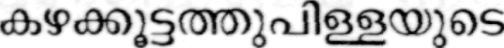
കഴക്കൂട്ടത്തുപിള്ളയുടെ
